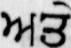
ਅਤੇ
